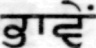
ਭਾਵੇਂ
